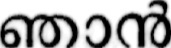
ഞാന്‍
